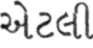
એટલી
